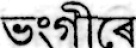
ভংগীৰে
